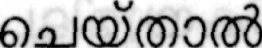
ചെയ്താല്‍
